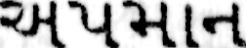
અપમાન
